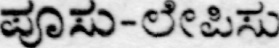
ಪೂಸು-ಲೇಪಿಸು
